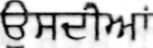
ਉਸਦੀਆਂ
